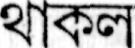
থাকল
